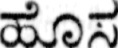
ಹೊಸ
